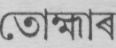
তোহ্মাৰ
